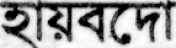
হায়বদো
